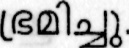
ഭ്രമിച്ചു.
